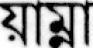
য়াম্না
